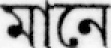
মানে
